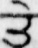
ਤੇ
